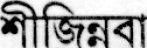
শীজিন্নবা
